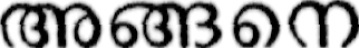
അങ്ങനെ
